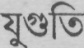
যুগুতি
